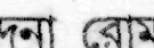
ঐখোয়গী
